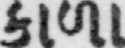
કાળા
